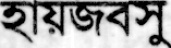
হায়জবসু
